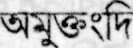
অমুক্তংদি
